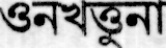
ওনখত্তুনা
